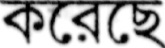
করেছে
